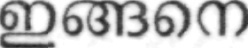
ഇങ്ങനെ
